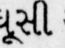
ઘૂસી
